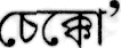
চেক্কো’
